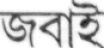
জবাই
